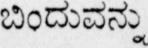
ಬಿಂದುವನ್ನು
